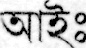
আইঃ
